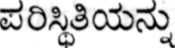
ಪರಿಸ್ಥಿತಿಯನ್ನು
